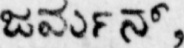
ಜರ್ಮನ್,
